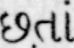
છતાં
